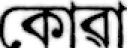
কোৱা
